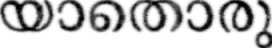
യാതൊരു
